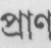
প্রাণ
